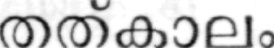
തത്കാലം
